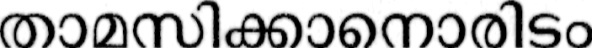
താമസിക്കാനൊരിടം
